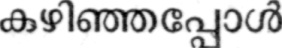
കഴിഞ്ഞപ്പോള്‍
